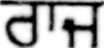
ਰਾਜ
